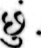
છું.
